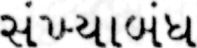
સંખ્યાબંધ
